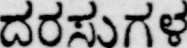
ದರಸುಗಳ
